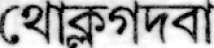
থোক্লগদবা
